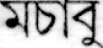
মচাবু
